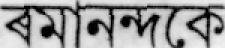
ৰমানন্দকে
